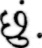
છું.
